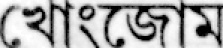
খোংজোম
